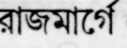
রাজমার্গে
